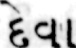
દેવા
